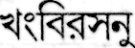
খংবিরসনু
